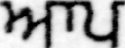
ਆਪ
